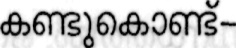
കണ്ടുകൊണ്ട്-
